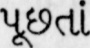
પૂછતાં
